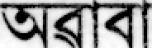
অৱাবা
